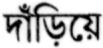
দাঁড়িয়ে
